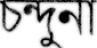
চন্দুনা
